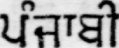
ਪੰਜਾਬੀ
